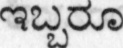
ಇಬ್ಬರೂ
